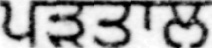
ਪੜਤਾਲ
